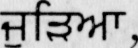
ਜੁੜਿਆ,
